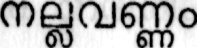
നല്ലവണ്ണം
